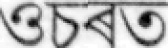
ওচৰত
